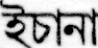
ইচানা
